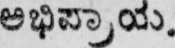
ಅಭಿಪ್ರಾಯ.
